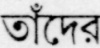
তাঁদের
